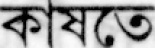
কাষতে
